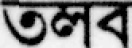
তলব
